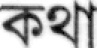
কথা
